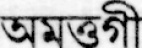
অমত্তগী
